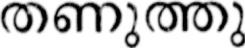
തണുത്തു
